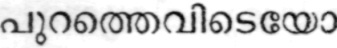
പുറത്തെവിടെയോ
